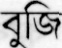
বুজি
